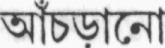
আঁচড়ানো
